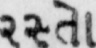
રસ્તો
